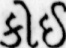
કોઈ
